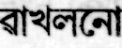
ৱাখলনো
